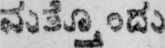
ಮತ್ತೊಂದು
